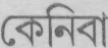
কেনিবা
